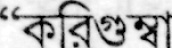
“করিগুম্বা
